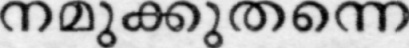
നമുക്കുതന്നെ
